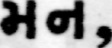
મન,
